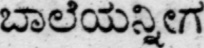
ಬಾಲೆಯನ್ನೀಗ
